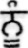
ਨੂੰ
